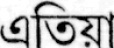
এতিয়া
